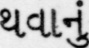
થવાનું
